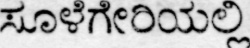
ಸೂಳೆಗೇರಿಯಲ್ಲಿ
